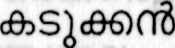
കടുക്കന്‍
